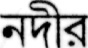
নদীর
